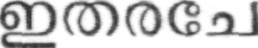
ഇതരചേ
